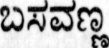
ಬಸವಣ್ಣ
